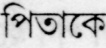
পিতাকে
